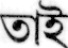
তাই
